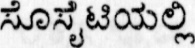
ಸೊಸೈಟಿಯಲ್ಲಿ
